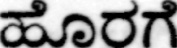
ಹೊರಗೆ
